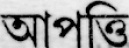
আপত্তি
